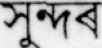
সুন্দৰ
